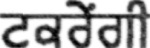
ਟਕਰੇਂਗੀ
